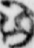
છે
